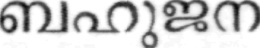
ബഹുജന
